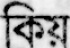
কিয়
